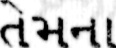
તેમના
